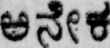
ಅನೇಕ
